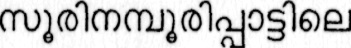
സൂരിനമ്പൂരിപ്പാട്ടിലെ
